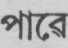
পাৱে
